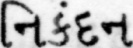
નિકંદન
